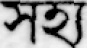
সহ্য
